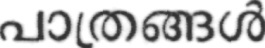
പാത്രങ്ങള്‍
